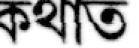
কথাত
